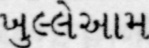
ખુલ્લેઆમ
